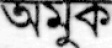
অমুক
